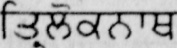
ਤ੍ਰਿਲੋਕਨਾਥ
